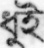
ধুই
